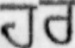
ਹਰ
